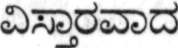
ವಿಸ್ತಾರವಾದ
